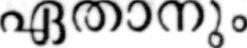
ഏതാനും
